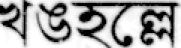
খঙহল্লে
